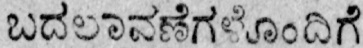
ಬದಲಾವಣೆಗಳೊಂದಿಗೆ
